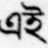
এই
